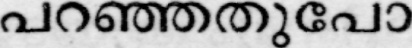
പറഞ്ഞതുപോ
